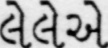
લેલેએ
